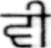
ਵੀ
